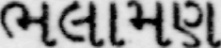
ભલામણ
